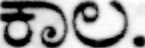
ಕಾಲ.
